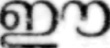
ഈ
